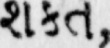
શકત,
